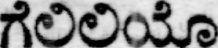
ಗೆಲಿಲಿಯೊ
